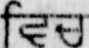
ਵਿਚ
